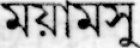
ময়ামসু
